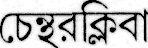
চেন্থরক্লিবা
